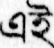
এই
